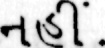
નહીં.
